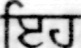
ਇਹ
